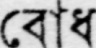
বোধ
